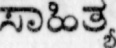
ಸಾಹಿತ್ಯ
